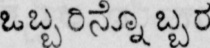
ಒಬ್ಬರಿನ್ನೊಬ್ಬರ
